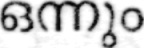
ഒന്നും
